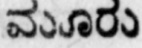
ಮೂರು
